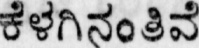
ಕೆಳಗಿನಂತಿವೆ
